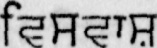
ਵਿਸਵਾਸ਼
